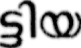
ട്ടിയ
